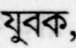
যুবক,
